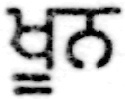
ਖੂਨ
